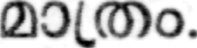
മാത്രം.
